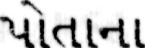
પોતાના
